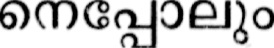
നെപ്പോലും
